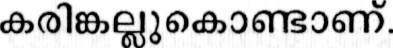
കരിങ്കല്ലുകൊണ്ടാണ്.
